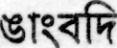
ঙাংবদি
